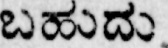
ಬಹುದು
